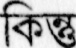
কিন্তু
